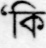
‘কি
